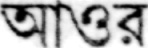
আওর
